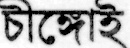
চীঙ্গোই
